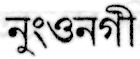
নুংওনগী
